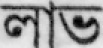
লাভ
